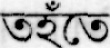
তহঁতে
